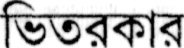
ভিতরকার
